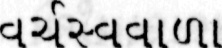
વર્ચસ્વવાળા
